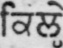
ਕਿਲ੍ਹੇ
